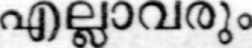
എല്ലാവരും
